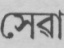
সেৱা
